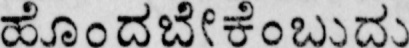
ಹೊಂದಬೇಕೆಂಬುದು
